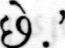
છે.'
